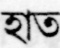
হাত
